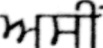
ਅਸੀਂ
